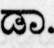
ಡಾ.
